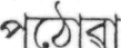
পঠোৱা
